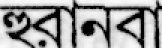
হুরানবা
